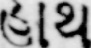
હાથ
